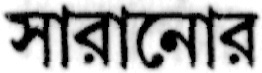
সারানোর
